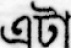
এটা
